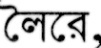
লৈরে,
